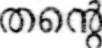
തന്റെ
